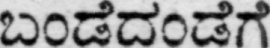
ಬಂಡೆದಂಡೆಗೆ
